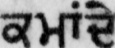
ਕਮਾਂਦੇ
